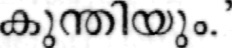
കുന്തിയും.'
